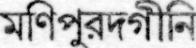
মণিপুরদগীনি
